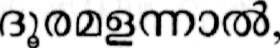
ദൂരമളന്നാല്‍,
